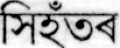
সিহঁতৰ
